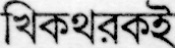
খিকথরকই
